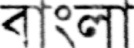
বাংলা
